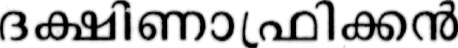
ദക്ഷിണാഫ്രിക്കന്‍
